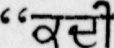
''ਕਦੀ
